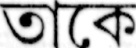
তাকে
